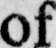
of
